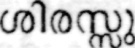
ശിരസ്സു
